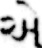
એ
